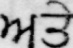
ਅਤੇ
